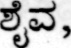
ಶೈವ,
